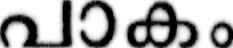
പാകം
